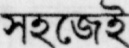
সহজেই
